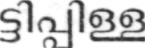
ട്ടിപ്പിള്ള
